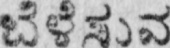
ಬೆಳೆಸುವ
